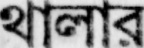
থালার
